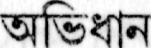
অভিধান
